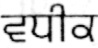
ਵਧੀਕ
